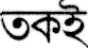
তকই
